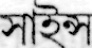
সাইন্স
